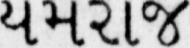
યમરાજ
